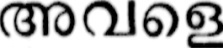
അവളെ
